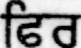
ਫਿਰ
